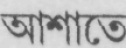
আশাতে
